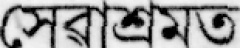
সেৱাশ্রমত
